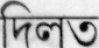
দিলত
